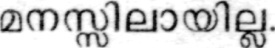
മനസ്സിലായില്ല.
